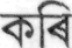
কৰি
